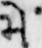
મેં
